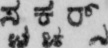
ಸ್ಟಕ್ಚರ್‍ಸ್
